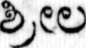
ಶ್ರೀಲ
